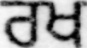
ਰਖ
